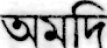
অমদিল
